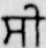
ਸੀ
